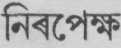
নিৰপেক্ষ
